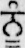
ਨੂੰ
